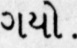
ગયો.
